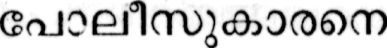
പോലീസുകാരനെ
